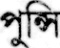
পুন্সি
